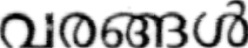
വരങ്ങള്‍
